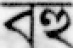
বহু
